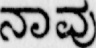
ನಾವು
